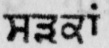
ਸੜਕਾਂ
